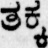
ತಕ್ಕ
